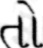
તો
